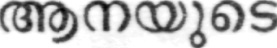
ആനയുടെ
